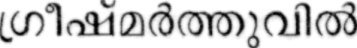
ഗ്രീഷ്മര്‍ത്തുവില്‍
